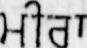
ਮੀਰਾ
